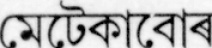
মেটেকাবোৰ
